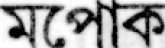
মপোক
